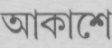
আকাশে
